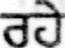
ਰਹੇ
